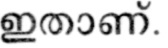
ഇതാണ്.
